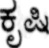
ಕೃಷಿ
